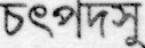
চৎপদসু
